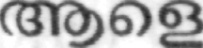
ആളെ
